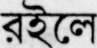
রইলে
